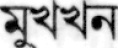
মুখখন
